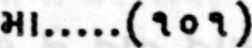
મા.....(૧૦૧)
